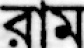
রাম
